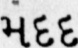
મદદ
